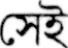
সেই
